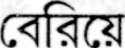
বেরিয়ে
